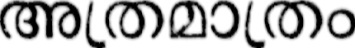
അത്രമാത്രം
